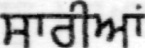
ਸਾਰੀਆਂ
